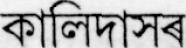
কালিদাসৰ
